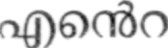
എന്റെ
